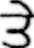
ਤੇ
